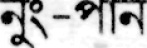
নুং-পান
